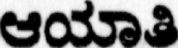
ಆಯಾತಿ
